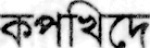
কপখিদে
